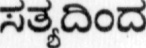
ಸತ್ಯದಿಂದ
